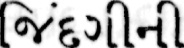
જિંદગીની
